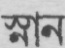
স্নান
